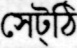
সেট্ঠি
